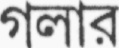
গলার
